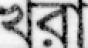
খরা
